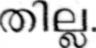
തില്ല.
